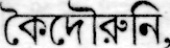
কৈদৌরুনি,
